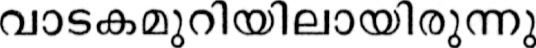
വാടകമുറിയിലായിരുന്നു
